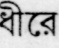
ধীরে
